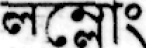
লম্লোং
